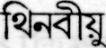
থিনবীয়ু
